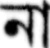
না
